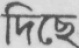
দিছে
